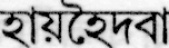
হায়হৈদবা
